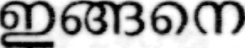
ഇങ്ങനെ
